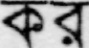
কর
